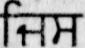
ਜਿਸ
